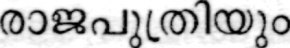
രാജപുത്രിയും
